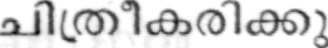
ചിത്രീകരിക്കു
